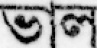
ভাল
